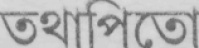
তথাপিতো
